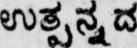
ಉತ್ಪನ್ನದ
